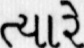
ત્યારે
